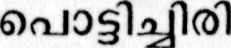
പൊട്ടിച്ചിരി
